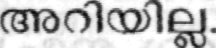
അറിയില്ല.
